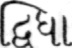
દ્વિધા
